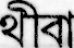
থীবা
